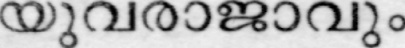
യുവരാജാവും
